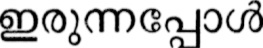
ഇരുന്നപ്പോള്‍
